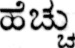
ಹೆಚ್ಚು
